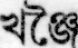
খঞ্জৈ
